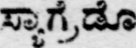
ಸ್ಯಾಗ್ರೆಡೊ
